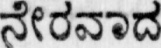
ನೇರವಾದ
